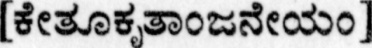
ಕೇತೂಕೃತಾಂಜನೇಯಂ]
